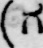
(ಗ
